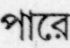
পারে
